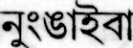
নুংঙাইবা
